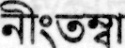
নীংতম্বা
